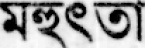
মহুৎতা
